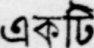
একটি
